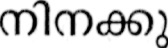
നിനക്കു
